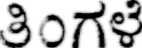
ತಿಂಗಳೆ
